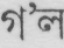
গ'ল
